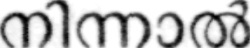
നിന്നാല്‍
